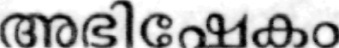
അഭിഷേകം
